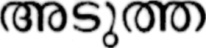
അടുത്ത
